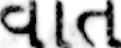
વાત
